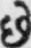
છે
